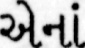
એનાં
